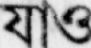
যাও
